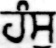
ਹੰਸੁ
